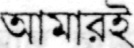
আমারই
